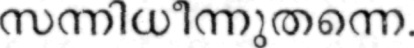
സന്നിധീന്നുതന്നെ.
